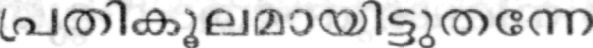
പ്രതികൂലമായിട്ടുതന്നേ
